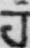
ਹੋ
